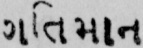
ગતિમાન
